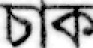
চাক
